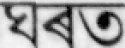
ঘৰত
